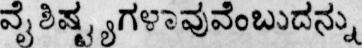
ವೈಶಿಷ್ಟ್ಯಗಳಾವುವೆಂಬುದನ್ನು
